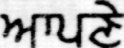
ਆਪਣੇ
